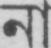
না
